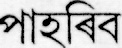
পাহৰিব
